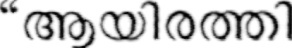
"ആയിരത്തി
